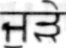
ਜੁੜੇ
